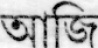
আজি
